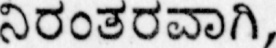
ನಿರಂತರವಾಗಿ,
